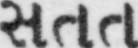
સતત
